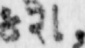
કરો,
